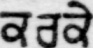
ਕਰਕੇ
